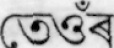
তেওঁৰ
